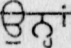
ਉਨ੍ਹਾਂ
